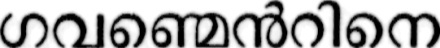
ഗവണ്മെൻറിനെ
